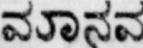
ಮಾನವ
